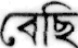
বেছি
